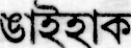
ঙাইহাক
